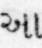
આ
